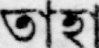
তাহা
